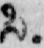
ಸಿ.
